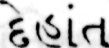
દેહાંત
